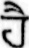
ਹੈ
